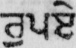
ਰੁਪਏ
